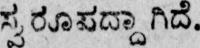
ಸ್ವರೂಪದ್ದಾಗಿದೆ.
